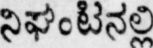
ನಿಘಂಟಿನಲ್ಲಿ
